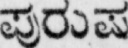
ಪುರುಷ
